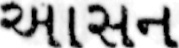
આસન
